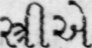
સ્ત્રીએ
